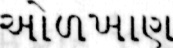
ઓળખાણ
